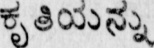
ಕೃತಿಯನ್ನು
